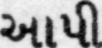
આપી
